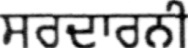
ਸਰਦਾਰਨੀ
